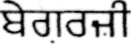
ਬੇਗ਼ਰਜੀ
